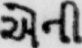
એની
